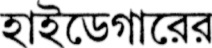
হাইডেগারের
